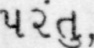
પરંતુ,
